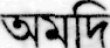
ইমদি
